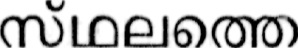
സ്ഥലത്തെ
